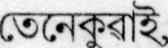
তেনেকুৱাই,
